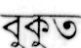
বুকুত
